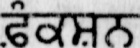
ਫ਼ੰਕਸ਼ਨ
